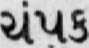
ચંપક
